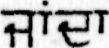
ਜਾਂਦਾ
